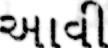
આવી
